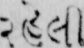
રહેલી
